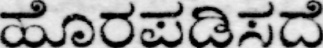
ಹೊರಪಡಿಸದೆ
